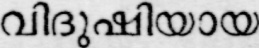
വിദുഷിയായ
